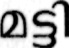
മട്ടി
